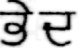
ਭੇਦ
